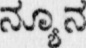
ನ್ಯೂನ
